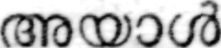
അയാള്‍
